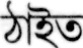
ঠাইত
